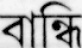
বান্ধি
